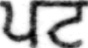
ਪਟ
